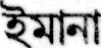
ইমানা
